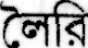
লৈরি
